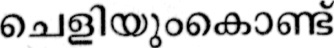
ചെളിയുംകൊണ്ട്
